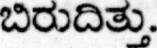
ಬಿರುದಿತ್ತು.
